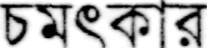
চমত্কার
